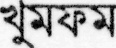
খুমফম
